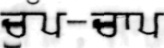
ਚੁੱਪ-ਚਾਪ
